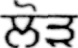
ਲੋੜ
